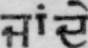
ਜਾਂਦੇ
